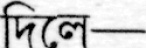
দিলে-
